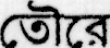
তৌরে
